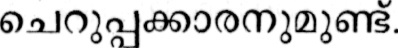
ചെറുപ്പക്കാരനുമുണ്ട്.
